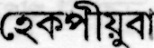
হেকপীয়ুবা
